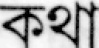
কথা
